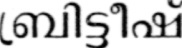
ബ്രിട്ടീഷ്
